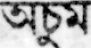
অচুম
